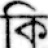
কি
